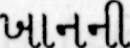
ખાનની
